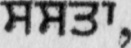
ਸਸਤਾ,
